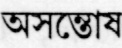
অসন্তোষ
